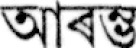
আৰম্ভ
